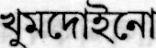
খুমদোইনো
